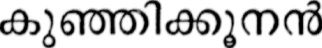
കുഞ്ഞിക്കൂനന്‍
